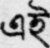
এই
